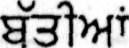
ਬੱਤੀਆਂ
